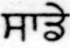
ਸਾਡੇ
